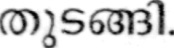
തുടങ്ങി.
